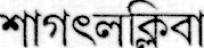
শাগৎলক্লিবা
